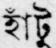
হাঁটু
